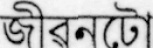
জীৱনটো
